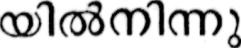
യില്‍നിന്നു
